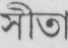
সীতা
